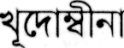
খূদোম্বীনা
